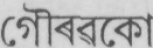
গৌৰৱকো
